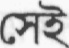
সেই
